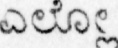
ಎಲ್ಲೋ
